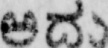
ಅದು
